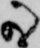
જે
